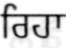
ਰਿਹਾ
